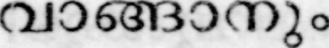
വാങ്ങാനും
